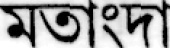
মতাংদা
